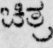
ಚಿತ್ರ
